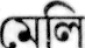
মেলি
